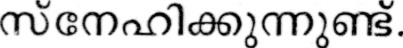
സ്നേഹിക്കുന്നുണ്ട്.
